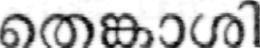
തെങ്കാശി
